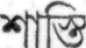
শাস্তি
